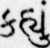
કહ્યું
